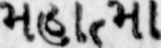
મહાત્મા
